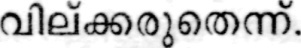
വില്ക്കരുതെന്ന്.
